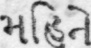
મહિને
